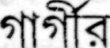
গার্গীর
